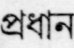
প্রধান
